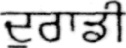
ਦੁਰਾਡੀ
